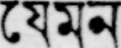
যেমন
